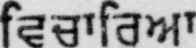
ਵਿਚਾਰਿਆ
